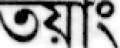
তয়াং
